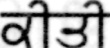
ਕੀਤੀ
